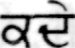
ਕਦੇ
